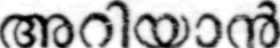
അറിയാന്‍
